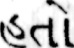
હતો
